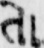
તો
